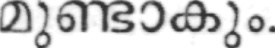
മുണ്ടാകും.
